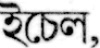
ইচেল,
